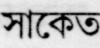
সাকেত
